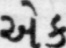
એક
